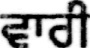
ਵਾਰੀ
